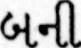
બની
